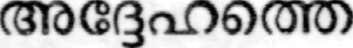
അദ്ദേഹത്തെ
